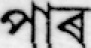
পাৰ
